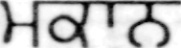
ਮਕਾਨ
